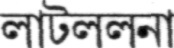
লাটললনা
